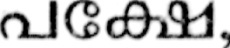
പക്ഷേ,
